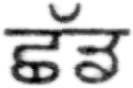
ਛੱਡ
